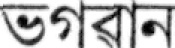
ভগৱান
